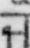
ਜੋ
